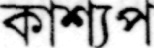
কাশ্যপ
